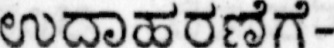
ಉದಾಹರಣೆಗೆ-
